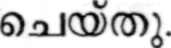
ചെയ്തു.
